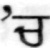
'ਚ
